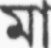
মা
